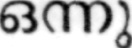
ഒന്നു
